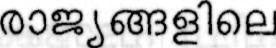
രാജ്യങ്ങളിലെ
